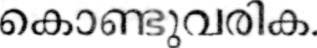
കൊണ്ടുവരിക.
